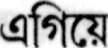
এগিয়ে
